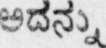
ಅದನ್ನು
